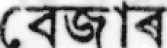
বেজাৰ
